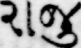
રાજુ
